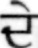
ਦੇ
